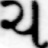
ચ
